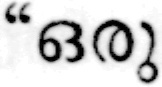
"ഒരു
